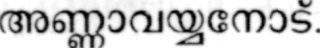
അണ്ണാവയ്യനോട്.
